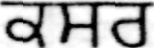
ਕਸਰ
